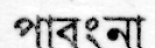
ঐখোয়না
